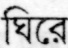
ঘিরে
